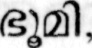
ഭൂമി,
